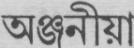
অঞ্জনীয়া
